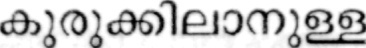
കുരുക്കിലാനുള്ള
